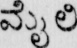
ಮೈಲಿ
